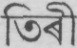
তিৰী
